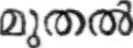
മുതല്‍
